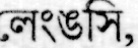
লেংঙসি,
